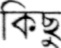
কিছু
